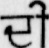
ਦੀ
